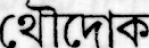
থৌদোক
